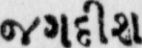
જગદીશ
